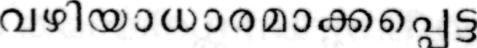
വഴിയാധാരമാക്കപ്പെട്ട
